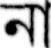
না
